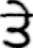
ਤੇ
